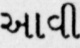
આવી
